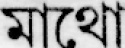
মাথো
